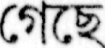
গেছে
